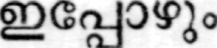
ഇപ്പോഴും
